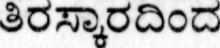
ತಿರಸ್ಕಾರದಿಂದ
